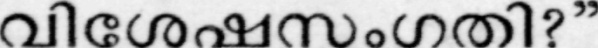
വിശേഷസംഗതി?"
